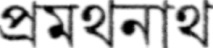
প্রমথনাথ
